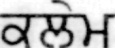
ਕਲੇਮ
